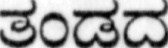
ತಂಡದ
